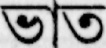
ভাত
